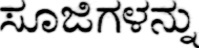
ಸೂಜಿಗಳನ್ನು
